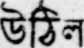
উঠিল
